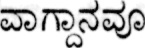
ವಾಗ್ದಾನವೂ
